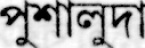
পুশালুদা
